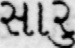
સારુ
